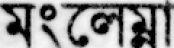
মংলেম্না
